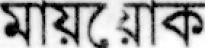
মায়য়োক
